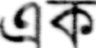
এক
